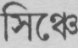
সিঞ্চে
